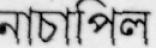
নাচাপিল
